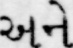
અને
